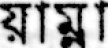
য়াম্না
